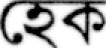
হেক
